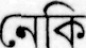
নেকি
